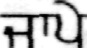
ਜਾਪੇ
